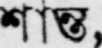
শান্ত,
